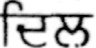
ਦਿਲ
